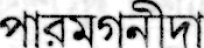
পারমগনীদা
